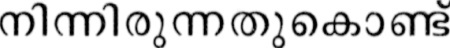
നിന്നിരുന്നതുകൊണ്ട്
